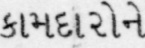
કામદારોને
